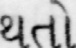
થતો
